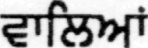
ਵਾਲਿਆਂ
